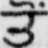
ਤੋਂ
